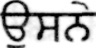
ਉਸਨੇ
